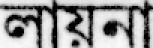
লায়না
